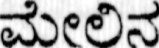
ಮೇಲಿನ
